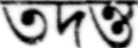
তদন্ত
